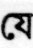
যে
